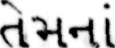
તેમનાં
